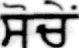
ਸੋਚੇਂ
